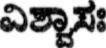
ವಿಶ್ವಾಸಃ
